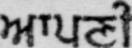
ਆਪਣੀ
